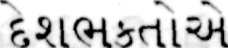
દેશભક્તોએ
